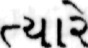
ત્યારે
